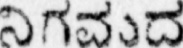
ನಿಗಮದ
